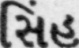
સિંહ
